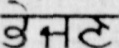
ਭੇਜਣ
